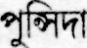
পুন্সিদা
